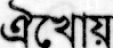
ঐখোয়
